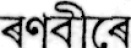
ৰণবীৰে
